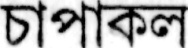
চাপাকল
